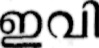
ഇവി
